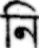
নি
